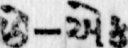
છે-એક
